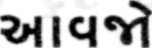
આવજો
